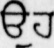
ਉਹ
